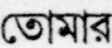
তোমার
